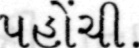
પહોંચી.
